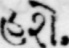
હશે.
